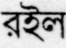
রইল
